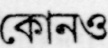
কোনও
